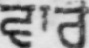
ਵਾਰ
